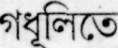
গধূলিতে
